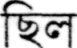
ছিল
